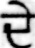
ਦੇ
